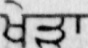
ਖੇੜਾ
